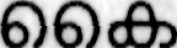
കൈ
